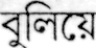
বুলিয়ে
